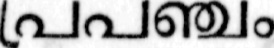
പ്രപഞ്ചം
